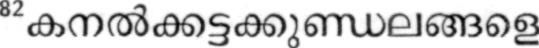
82കനല്‍ക്കട്ടക്കുണ്ഡലങ്ങളെ
